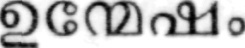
ഉന്മേഷം
